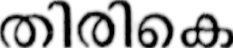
തിരികെ
